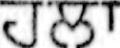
ਹਲਾ
